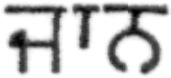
ਜਾਨ
